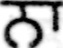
ਨਾ
